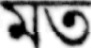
মত
